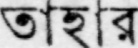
তাহার
